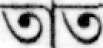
তাত
